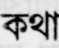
কথা
